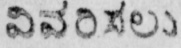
ವಿವರಿಸಲು
